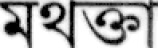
মথক্তা
